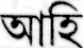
আহি
